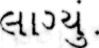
લાગ્યું.
